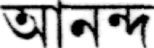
আনন্দ
